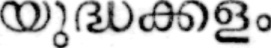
യുദ്ധക്കളം
